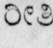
ರೀತಿ
